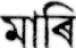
মাৰি
